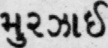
મુરઝાઈ
